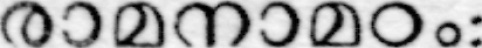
രാമനാമഠം:
